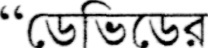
“ডেভিডের
